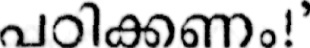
പഠിക്കണം!’
